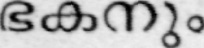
ഭകനും
